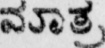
ಮಾತ್ರ
